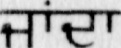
ਜਾਂਦਾ
